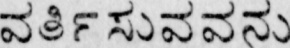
ವರ್ತಿಸುವವನು
